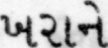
ખરાને
